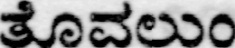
ತೊವಲುಂ
